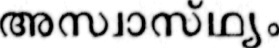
അസ്വാസ്ഥ്യം
